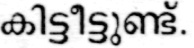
കിട്ടീട്ടുണ്ട്.
